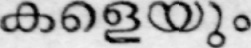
കളെയും
